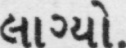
લાગ્યો.
